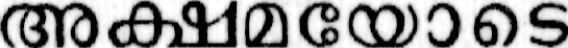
അക്ഷമയോടെ
